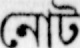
নোট
